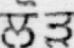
ਲੋੜ
